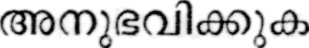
അനുഭവിക്കുക
